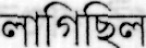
লাগিছিল
